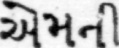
એમની
